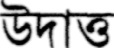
উদাত্ত
